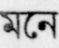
মনে
